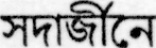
সদার্জীনে
